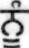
ਨੂੰ
